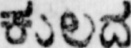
ಕುಲದ
